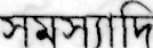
সমস্যাদি
